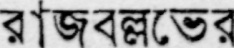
রাজবল্লভের
